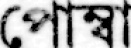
পোম্বা
